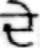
ਦੇ
